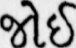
જોઈ
